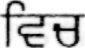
ਵਿਚ
